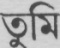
তুমি
